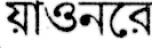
য়াওনরে
